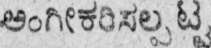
ಅಂಗೀಕರಿಸಲ್ಪಟ್ಟ
